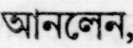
আনলেন,
